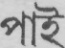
পাই
